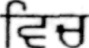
ਵਿਚ
